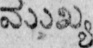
ಮುಖ್ಯ
